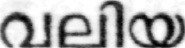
വലിയ
